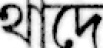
থাদে
